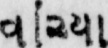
વાંચ્યા
